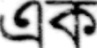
এক
